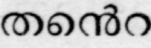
തന്റെ
